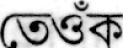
তেওঁক
